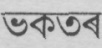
ভকতৰ
